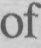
of
